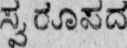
ಸ್ವರೂಪದ
